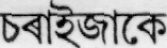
চৰাইজাকে
